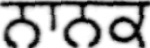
ਨਾਨਕ
